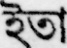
ইতা
